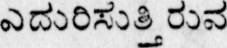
ಎದುರಿಸುತ್ತಿರುವ
